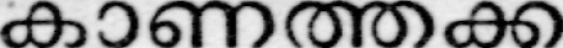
കാണത്തക്ക
